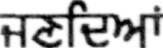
ਜਣਦਿਆਂ
